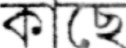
কাছে
